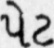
પેટ
